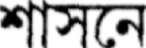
শাসনে
